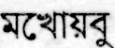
মখোয়বু
